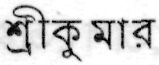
শ্রীকুমার
